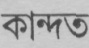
কান্দত
